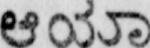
ಆಯಾ
